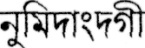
নুমিদাংদগী
